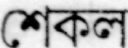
শেকল
